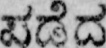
ಪಡೆದ
